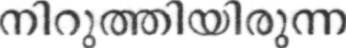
നിറുത്തിയിരുന്ന
